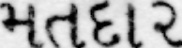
મતદાર
